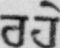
ਰਹੇ
